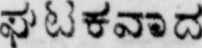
ಘಟಕವಾದ
